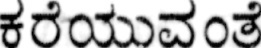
ಕರೆಯುವಂತೆ
